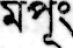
মপূং
